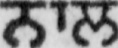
ਨਾਲ
